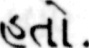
હતો.
